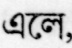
এলে,
